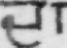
ਦਾ
